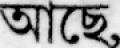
আছে,
